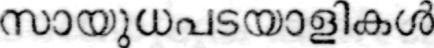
സായുധപടയാളികള്‍
